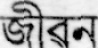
জীৱন
